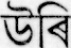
উৰি
